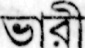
ভারী
